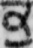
ਕੁ
